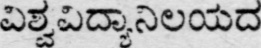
ವಿಶ್ವವಿದ್ಯಾನಿಲಯದ
